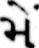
મેં
